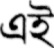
এই
